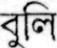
বুলি
